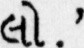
લો.'
